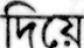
দিয়ে
